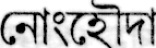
নোংহৌদা
